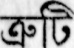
ত্রুটি
